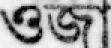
ওজা
